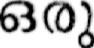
ഒരു
